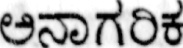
ಅನಾಗರಿಕ
